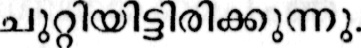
ചുറ്റിയിട്ടിരിക്കുന്നു.
